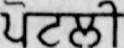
ਪੋਟਲੀ
